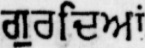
ਗੁਰਦਿਆਂ
